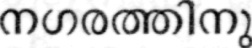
നഗരത്തിനു
